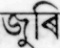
জুৰি
